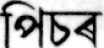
পিচৰ
